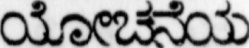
ಯೋಚನೆಯ
